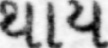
થાય
